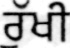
ਰੁੱਖੀ
